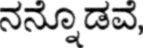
ನನ್ನೊಡವೆ,
